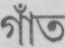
গাঁত
